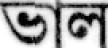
ভাল
